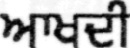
ਆਖਦੀ
